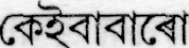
কেইবাবাৰো
